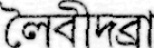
লৈবীদব্রা
